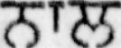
ਨਾਲ
